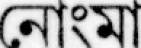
নোংমা
